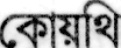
কোয়থি
